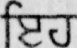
ਇਹ
